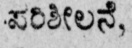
ಪರಿಶೀಲನೆ,
